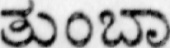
ತುಂಬಾ
